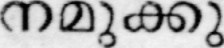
നമുക്കു
